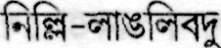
নিল্লি-লাঙলিবদু
